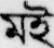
মই
